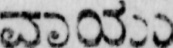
ವಾಯು
